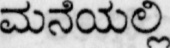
ಮನೆಯಲ್ಲಿ
